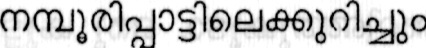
നമ്പൂരിപ്പാട്ടിലെക്കുറിച്ചും
